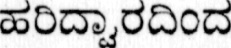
ಹರಿದ್ವಾರದಿಂದ
